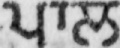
ਪਾਲ
